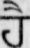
ਹੈ
